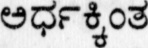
ಅರ್ಧಕ್ಕಿಂತ
